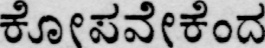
ಕೋಪವೇಕೆಂದ
